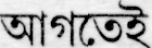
আগতেই
